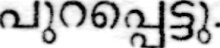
പുറപ്പെട്ടു.
